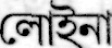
লোইনা
